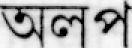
অলপ
